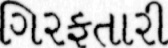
ગિરફ્તારી
